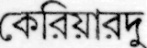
কেরিয়ারদু
